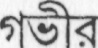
গভীর
